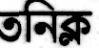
তনিক্ল
